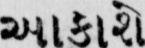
ઈશાને
